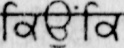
ਕਿਉਂਕਿ
